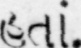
હતાં.
